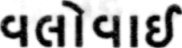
વલોવાઈ
